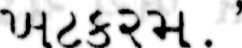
ખટકરમ.
